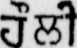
ਹੌਲੀ
